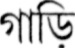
গাড়ি
